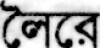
লৈরে
